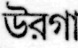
উরগা
